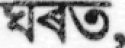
ঘৰত,
